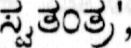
ಸ್ವತಂತ್ರ’,
